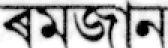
ৰমজান
